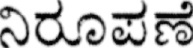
ನಿರೂಪಣೆ
